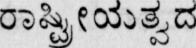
ರಾಷ್ಟ್ರೀಯತ್ವದ
